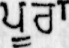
ਪੂਰਾ
